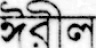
ঈরীল
